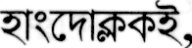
হাংদোক্লকই,
